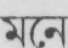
মনে
